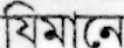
যিমানে
